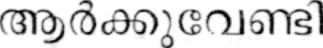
ആര്‍ക്കുവേണ്ടി
